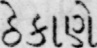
ઠેકાણે
